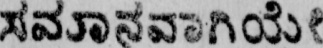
ಸಮಾನವಾಗಿಯೇ
